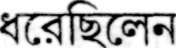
ধরেছিলেন
